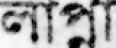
লাপ্না
